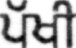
ਪੱਖੀ
